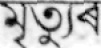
মৃত্যুৰ
